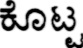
ಕೊಟ್ಟ
